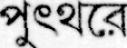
পুৎথরে
